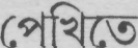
পেখিতে
